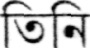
তিনি
